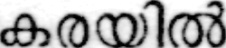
കരയില്‍
